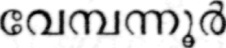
വേമ്പന്നൂര്‍
